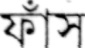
ফাঁস
